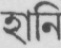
হানি
